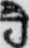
ਹੈ
